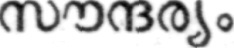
സൌന്ദര്യം
